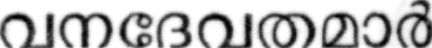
വനദേവതമാര്‍
